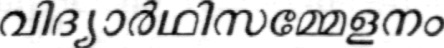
വിദ്യാര്‍ഥിസമ്മേളനം
